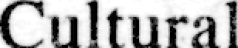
Cultural
